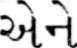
એને
